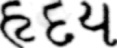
હ્રદય
